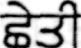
ਛੇਤੀ
